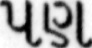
પણ
